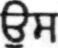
ਉਸ
